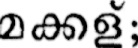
മക്കള്;
